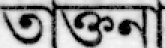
তাক্তনা
